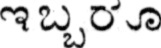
ಇಬ್ಬರೂ
